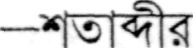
–শতাব্দীর
